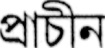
প্রাচীন
